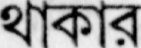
থাকার
